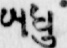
બધું
